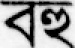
বহু
